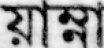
য়াম্না
